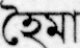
হৈমা
